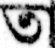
তা
